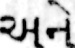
અને
